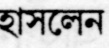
হাসলেন
